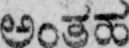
ಅಂತಹ
